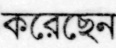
করেছেন
